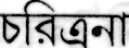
চরিত্রনা
